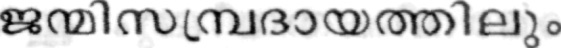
ജന്മിസമ്പ്രദായത്തിലും
